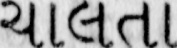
ચાલતા
